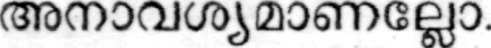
അനാവശ്യമാണല്ലോ.
